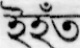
ইহঁত
